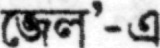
জেল’-এ
